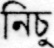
নিচু
